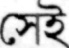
সেই
